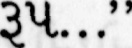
રૂપ..."
